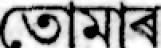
তোমাৰ
